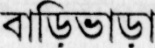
বাড়িভাড়া
